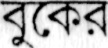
বুকের
